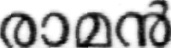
രാമന്‍
